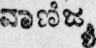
ವಾಣಿಜ್ಯ
